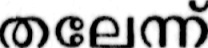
തലേന്ന്
